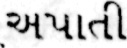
અપાતી
